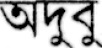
অদুবু
